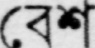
বেশ
